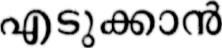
എടുക്കാന്‍
